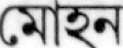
মোহন
